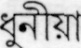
ধুনীয়া
